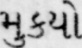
મુક્યો
